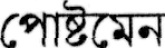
পোষ্টমেন
